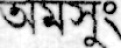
অমসুং
